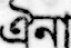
ঐনা
